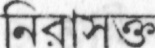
নিরাসক্ত
